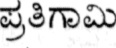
ಪ್ರತಿಗಾಮಿ
